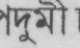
পদুমী
